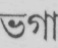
ভগা
